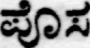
ಪೊಸ
